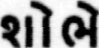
શોભે
